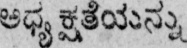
ಅಧ್ಯಕ್ಷತೆಯನ್ನು
